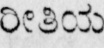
ರೀತಿಯ
